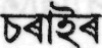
চৰাইৰ
